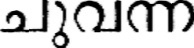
ചുവന്ന
